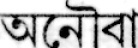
অনৌবা
